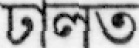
ঢালত
